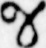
જ
